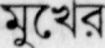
মুখের
